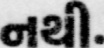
નથી.
